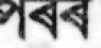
পৰৰ
